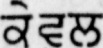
ਕੇਵਲ
